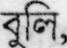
বুলি,
